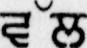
ਵੱਲ
